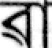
ৱা
